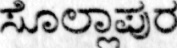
ಸೊಲ್ಲಾಪುರ
